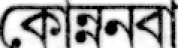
কোন্ননবা
